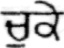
ਚੁਕੇ
